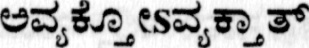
ಅವ್ಯಕ್ತೋsವ್ಯಕ್ತಾತ್
